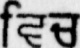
ਵਿਚ
